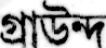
গ্রাউন্দ
